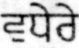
ਵਧੇਰੇ
